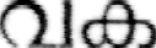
വക
